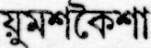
য়ুমশকৈশা
